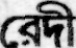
রেদী
